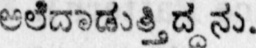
ಅಲೆದಾಡುತ್ತಿದ್ದನು.
